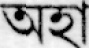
অহা
